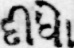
દીધો
